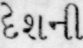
દેશની
